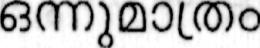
ഒന്നുമാത്രം
